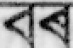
বৰ
